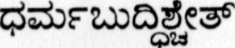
ಧರ್ಮಬುದ್ಧಿಶ್ಚೇತ್
